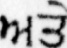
ਅਤੇ
